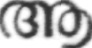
ആ
